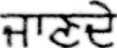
ਜਾਣਦੇ
